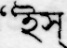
"ইস্
